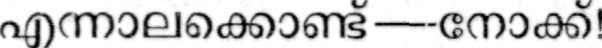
എന്നാലക്കൊണ്ട്-നോക്ക്!
